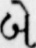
બે
